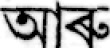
আৰু
